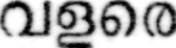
വളരെ
